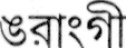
ঙরাংগী
